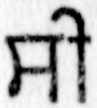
ਸੀ
